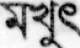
মখুৎ
